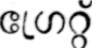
ഗ്രേറ്റ്
